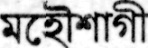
মহৌশাগী
